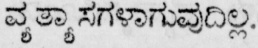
ವ್ಯತ್ಯಾಸಗಳಾಗುವುದಿಲ್ಲ.
